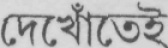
দেখোঁতেই
